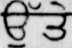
ਉੱਤੇ
